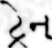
ટ્રેન
